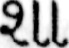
શા
